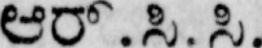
ಆರ್.ಸಿ.ಸಿ.
